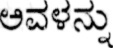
ಅವಳನ್ನು
